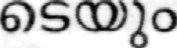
ടെയും
